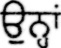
ਉਨ੍ਹਾਂ
